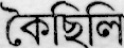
কৈছিলি
